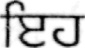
ਇਹ
